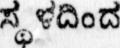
ಸ್ಥಳದಿಂದ
